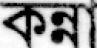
কন্না
